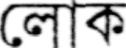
লোক
